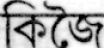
কিজৈ
